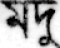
মদু
